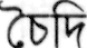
চৈদি
